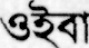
ওইবা
